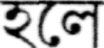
হলে
